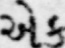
એક
